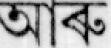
আৰু
